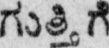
ಗುತ್ತಿಗೆ
